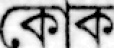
কোক
